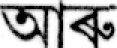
আৰু
